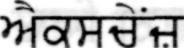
ਐਕਸਚੇਂਜ
